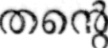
തന്റെ
